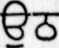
ਉਠ
